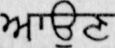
ਆਉਣ
